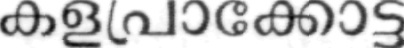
കളപ്രാക്കോട്ട
